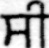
ਸੀ
